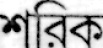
শরিক
